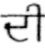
ਦੀ
